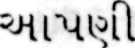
આપણી
